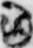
છે
